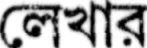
লেখার
